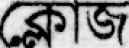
ক্লোজ
